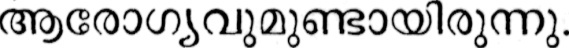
ആരോഗ്യവുമുണ്ടായിരുന്നു.
